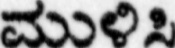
ಮುಳಿಸಿ
